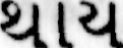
થાય
